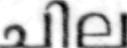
ചില
